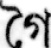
গৈ
